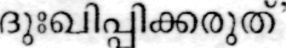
ദുഃഖിപ്പിക്കരുത്’
